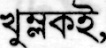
খুম্লকই,
